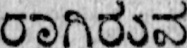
ರಾಗಿರುವ
